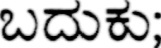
ಬದುಕು;
